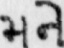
મને
